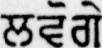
ਲਵੋਗੇ
